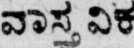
ವಾಸ್ತವಿಕ
